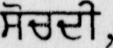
ਸੋਚਦੀ,
